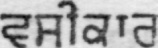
ਵਸੀਕਾਰ
